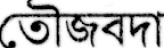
তৌজবদা
